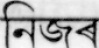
নিজৰ
